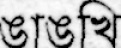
ঙাঙখি
